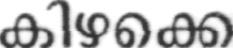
കിഴക്കെ
